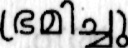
ഭ്രമിച്ചു
